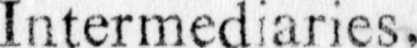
Intermediaries,
